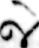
જે
